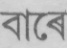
বাৰে
